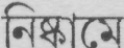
নিষ্কামে
